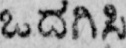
ಒದಗಿಸಿ
